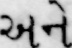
અને
